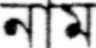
নাম
